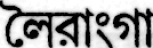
লৈরাংগা
